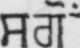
ਸਗੋਂ
